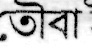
তৌবা
